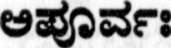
ಅಪೂರ್ವಃ
